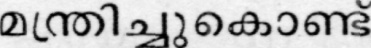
മന്ത്രിച്ചുകൊണ്ട്
